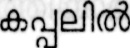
കപ്പലില്‍
